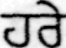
ਹਰੇ
